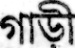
গাড়ী
